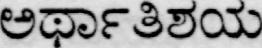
ಅರ್ಥಾತಿಶಯ
